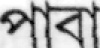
পাবা
